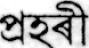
প্রহৰী
